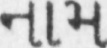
નામ
